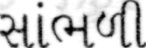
સાંભળી
